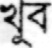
খুব
